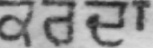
ਕਰਦਾ
